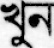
খুন
